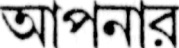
আপনার
